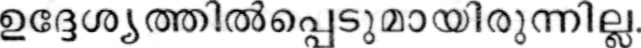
ഉദ്ദേശ്യത്തില്‍പ്പെടുമായിരുന്നില്ല.
